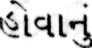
હોવાનું
